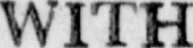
WITH
